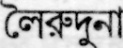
লৈরুদুনা
